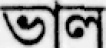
ভাল
